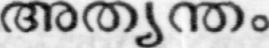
അത്യന്തം
